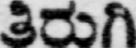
ತಿರುಗಿ
